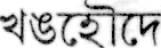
খঙহৌদে
